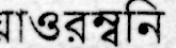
য়াওরম্বনি
